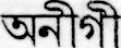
অনীগী
